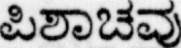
ಪಿಶಾಚವು
